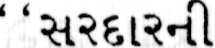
"સરદારની
